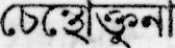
চেন্থোক্তুনা
